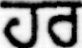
ਹਰ
